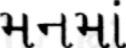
મનમાં
